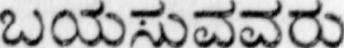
ಬಯಸುವವರು
